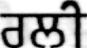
ਰਲੀ
